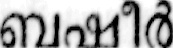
ബഷീര്‍
